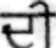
ਦੀ
